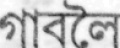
গাবলৈ
